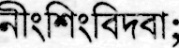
নীংশিংবিদবা;
